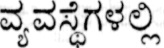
ವ್ಯವಸ್ಥೆಗಳಲ್ಲಿ
